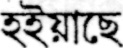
হইয়াছে
